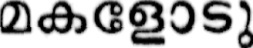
മകളോടു
